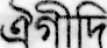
ঐগীদি
